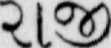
રાજી
